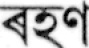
ৰহণ
